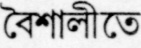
বৈশালীতে
